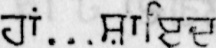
ਹਾ.ਸ਼ਾਇਦ
